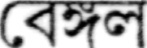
বেঙ্গল
